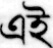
এই
